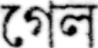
গেল
